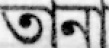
তানা
